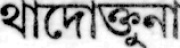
থাদোক্তুনা
